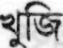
খুজি
